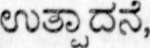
ಉತ್ಪಾದನೆ,
